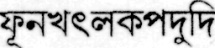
ফূনখৎলকপদুদি
